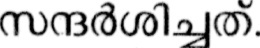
സന്ദര്‍ശിച്ചത്.
